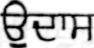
ਉਦਾਸ
